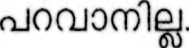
പറവാനില്ല.
